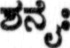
ಶನೈಃ
